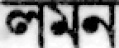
লমন
